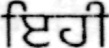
ਇਹੀ
